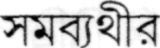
সমব্যথীর
